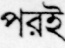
পরই
